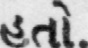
હતો.
